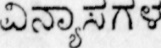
ವಿನ್ಯಾಸಗಳ
